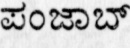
ಪಂಜಾಬ್
